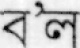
ব'ল
